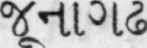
જૂનાગઢ
